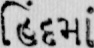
હિંદમાં
